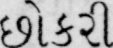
છોકરી
